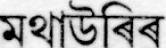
মথাউৰিৰ
